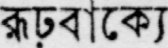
রূঢ়বাক্যে
